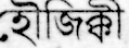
হৌজিক্কী
